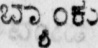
ಬ್ಯಾಂಕು
